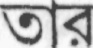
তার
